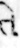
તે
